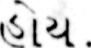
હોય.
